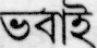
ভবাই
